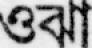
ওঝা
